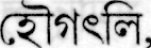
হৌগৎলি,
